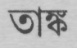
তাঙ্ক
